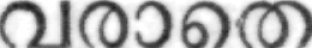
വരാതെ
